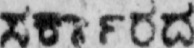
ಸರ್ಕಾರದ
